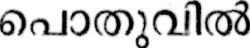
പൊതുവില്‍
